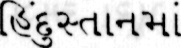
હિંદુસ્તાનમાં
